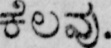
ಕೆಲವು.
